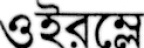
ওইরম্লে
